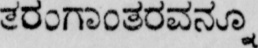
ತರಂಗಾಂತರವನ್ನೂ
